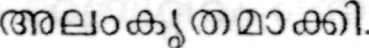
അലംകൃതമാക്കി.
